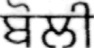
ਬੋਲੀ
